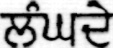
ਲੰਘਦੇ
